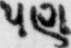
પણ
